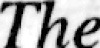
The
